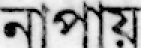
নাপায়
